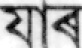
যাৰ
